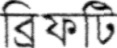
ব্রিফটি
